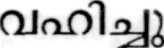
വഹിച്ചു
